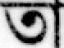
তা
